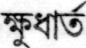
ক্ষুধার্ত
